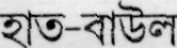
হাত-বাউল
